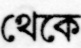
থেকে
